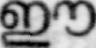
ഈ
